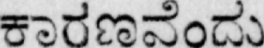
ಕಾರಣವೆಂದು
